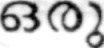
ഒരു
